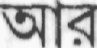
আর
